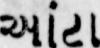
આંટા
